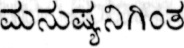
ಮನುಷ್ಯನಿಗಿಂತ
